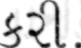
કરી.
